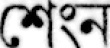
শেংন
